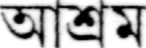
আশ্রম
